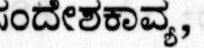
ಸಂದೇಶಕಾವ್ಯ,
